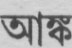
আঙ্ক
